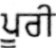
ਪੂਰੀ
